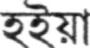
হইয়া
